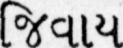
જિવાય
